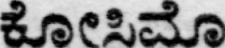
ಕೋಸಿಮೊ
